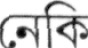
নেকি
